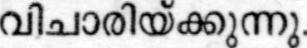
വിചാരിയ്ക്കുന്നു.
